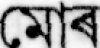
মোৰ
